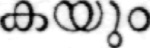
കയും
